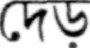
দেড়
